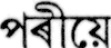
পৰীয়ে
